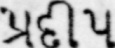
પ્રદીપ
